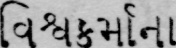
વિશ્વકર્માના
